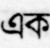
এক
